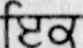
ਇਕ
